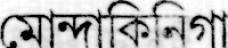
মোন্দাকিনিগা
